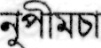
নুপীমচা
